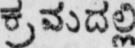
ಕ್ರಮದಲ್ಲಿ
